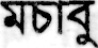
মচাবু
